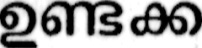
ഉണ്ടക്ക
